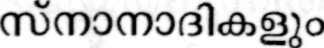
സ്നാനാദികളും
